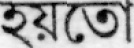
হয়তো
